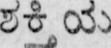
ಶಕ್ತಿಯ
